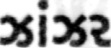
ઝાંઝર
